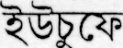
ইউচুফে
